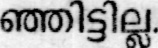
ഞ്ഞിട്ടില്ല.
